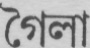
গৈলা
